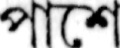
পাশে
